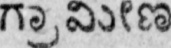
ಗ್ರಾಮೀಣ
